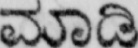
ಮಾಡಿ
